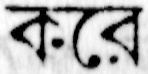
করে
